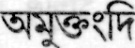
অমুক্তংদি
